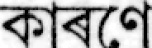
কাৰণে
